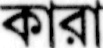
কারা
